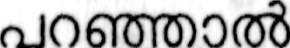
പറഞ്ഞാല്‍
